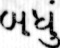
બધું
